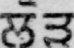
ਲੋੜ
